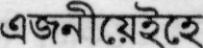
এজনীয়েইহে
